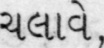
ચલાવે,
